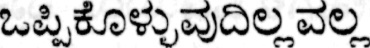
ಒಪ್ಪಿಕೊಳ್ಳುವುದಿಲ್ಲವಲ್ಲ
